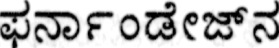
ಫರ್ನಾಂಡೇಜ್ ನ
